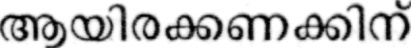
ആയിരക്കണക്കിന്
